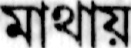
মাথায়
